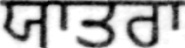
ਯਾਤਰਾ
